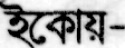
ইকোয়-
